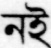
নই
